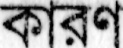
কারণ
